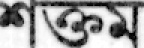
শক্তম
